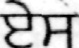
ਏਸ
